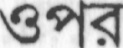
ওপর
